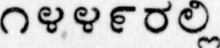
೧೪೪೯ರಲ್ಲಿ
